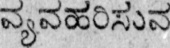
ವ್ಯವಹರಿಸುವ
